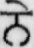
ਨੇ
